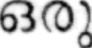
ഒരു
